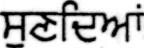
ਸੁਣਦਿਆਂ
